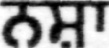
ਨਸ਼ਾ
